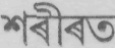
শৰীৰত
